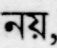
নয়,
